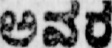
ಅವರ
